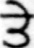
ਤੇ
